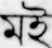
মই
